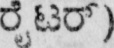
ರೈಟರ್)
